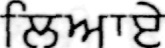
ਲਿਆਏ
